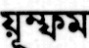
য়ূম্ফম
